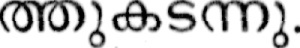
ത്തുകടന്നു.
